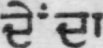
ਦੇਂਦਾ
